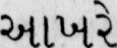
આખરે
